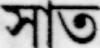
সাত
